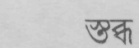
স্তব্ধ
